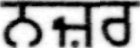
ਨਜ਼ਰ
